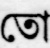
তো
